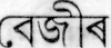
বেজীৰ
